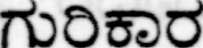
ಗುರಿಕಾರ
